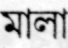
মালা
